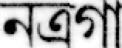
নত্রগা
